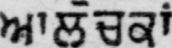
ਆਲੋਚਕਾਂ
